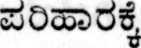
ಪರಿಹಾರಕ್ಕೆ
